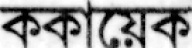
ককায়েক
